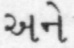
અને
